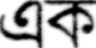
এক
